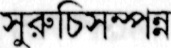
সুরুচিসম্পন্ন
